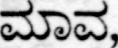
ಮಾವ,
